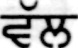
ਵੱਲ
